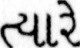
ત્યારે
